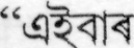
"এইবাৰ
